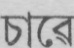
চাৱে
